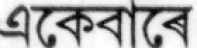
একেবাৰে
